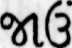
જાઉં
